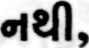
નથી,
